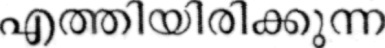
എത്തിയിരിക്കുന്ന
